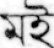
মই
